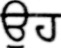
ਉਹ
